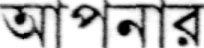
আপনার
